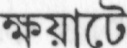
ক্ষয়াটে
